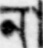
না
